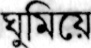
ঘুমিয়ে
